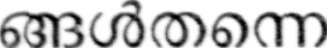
ങ്ങള്‍തന്നെ
